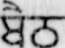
ਬੈਠ
